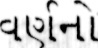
વર્ણનો
